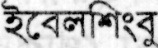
ইবেলসিংবু
